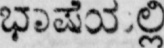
ಭಾಷೆಯಲ್ಲಿ
